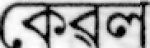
কেৱল
